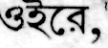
ওইরে,
